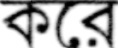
করে
